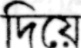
দিয়ে
